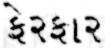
ફેરફાર
